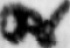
જ
